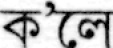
ক'লে
